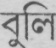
বুলি
